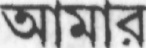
আমার
